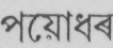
পয়োধৰ
